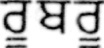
ਰੁਬਰੂ
